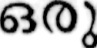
ഒരു
